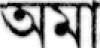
অম
